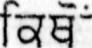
ਕਿਥੋਂ
